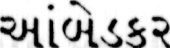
આંબેડકર
